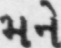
મને
